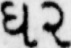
ઘર
